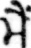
ਮੈਂ
